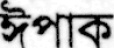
ঈপাক
